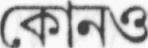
কোনও
